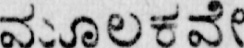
ಮೂಲಕವೇ
